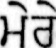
ਮੇਰੇ
